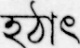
হঠাৎ
